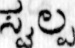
ಸ್ವಲ್ಪ
